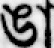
ঙা
